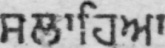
ਸਲਾਹਿਆ
